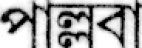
পাল্লবা
